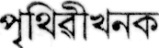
পৃথিৱীখনক
